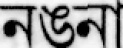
নঙনা
